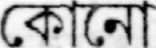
কোনো
